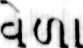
વેળા
